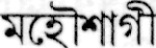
মহৌশাগী
